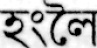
হংলৈ
